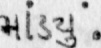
માંડ્યું.
